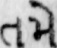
તમે
